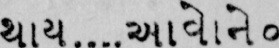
થાય....આવો
